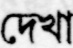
দেখা
